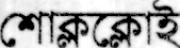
শোক্লক্লোই
